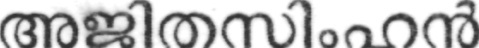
അജിതസിംഹന്‍
